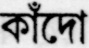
কাঁদো
